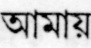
আমায়
